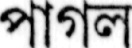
পাগল
